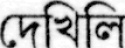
দেখিলি
